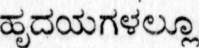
ಹೃದಯಗಳಲ್ಲೂ
